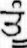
ਤੂੰ
